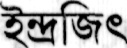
ইন্দ্রজিৎ
